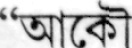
"আকৌ
